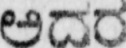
ಅದರ
